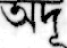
অদূ
